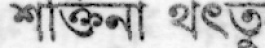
পঙৱা-ৱারগা,
